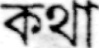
কথা
